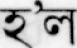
হ'ল
